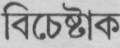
বিচেষ্টাক
